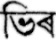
ভিৰ
